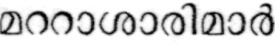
മററാശാരിമാര്‍
